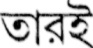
তারই
